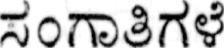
ಸಂಗಾತಿಗಳೆ
